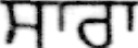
ਸਾਰਾ
